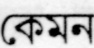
কেমন
